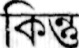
কিন্তু
